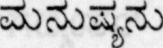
ಮನುಷ್ಯನು
